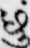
છું.
